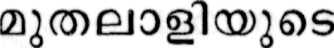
മുതലാളിയുടെ
